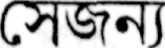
সেজন্য
